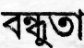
বন্ধুতা
